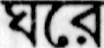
ঘরে
